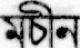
মচীন
